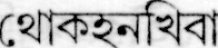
থোকহনখিবা
